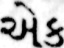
એક
